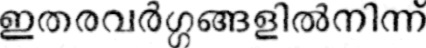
ഇതരവര്‍ഗ്ഗങ്ങളില്‍നിന്ന്
